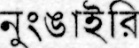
নুংঙাইরি
